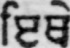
ਇਥੇ
